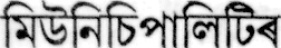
মিউনিচিপালিটিৰ
